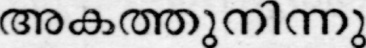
അകത്തുനിന്നു
